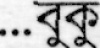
...বুকু
